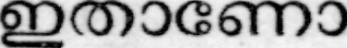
ഇതാണോ
